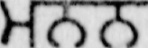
ਮਨਨ
